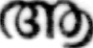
ആ
